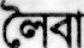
লৈবা
